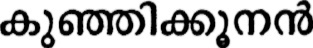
കുഞ്ഞിക്കൂനന്‍
